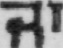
ਜਾ
